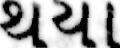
થયા
